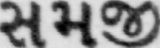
સમજી
